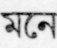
মনে
